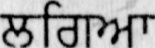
ਲਗਿਆ
